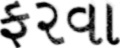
ફરવા
